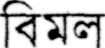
বিমল
